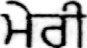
ਮੇਰੀ
